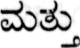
ಮತ್ತು
